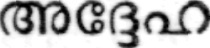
അദ്ദേഹ
